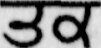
ਤਕ
